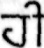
ਹੀ
